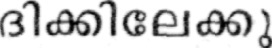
ദിക്കിലേക്കു
